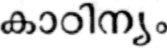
കാഠിന്യം
